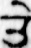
ਤੇ
